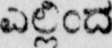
ಎಲ್ಲಿಂದ
